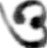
ও
